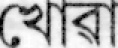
খোৱা
